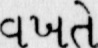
વખતે
